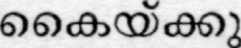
കൈയ്ക്കു
